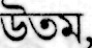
উতম,
